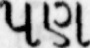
પણ
